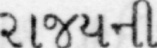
રાજ્યની
